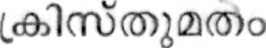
ക്രിസ്തുമതം
